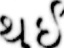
થઈ
